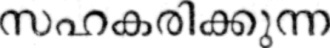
സഹകരിക്കുന്ന
